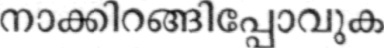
നാക്കിറങ്ങിപ്പോവുക
